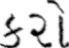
કરો
